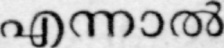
എന്നാല്‍
